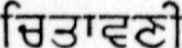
ਚਿਤਾਵਣੀ
